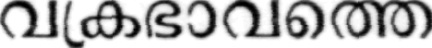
വക്രഭാവത്തെ
